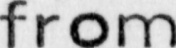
from
